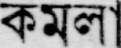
কমলা
